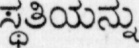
ಸ್ಥತಿಯನ್ನು
